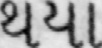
થયા
